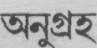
অনুগ্ৰহ
